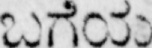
ಬಗೆಯ
